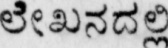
ಲೇಖನದಲ್ಲಿ
